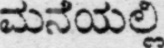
ಮನೆಯಲ್ಲಿ
